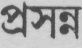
প্ৰসন্ন
